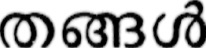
തങ്ങള്‍
